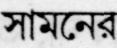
সামনের
